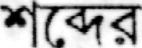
শব্দের
